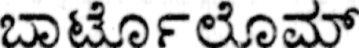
ಬಾರ್ಟೊಲೊಮ್
